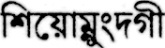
শিয়োম্নুংদগী
